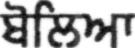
ਬੋਲਿਆ
